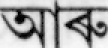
আৰু
